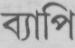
ব্যাপি
